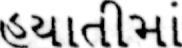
હયાતીમાં
